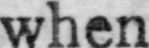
when
